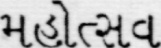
મહોત્સવ
